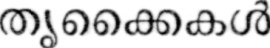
തൃക്കൈകള്‍
